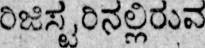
ರಿಜಿಸ್ಟರಿನಲ್ಲಿರುವ
